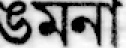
ঙমনা
